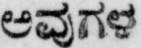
ಅವುಗಳ
